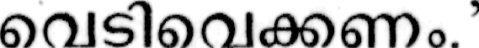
വെടിവെക്കണം.’
